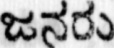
ಜನರು
